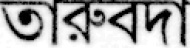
তারুবদা
